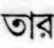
তার
